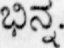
ಭಿನ್ನ.
